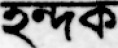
হন্দক
